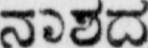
ನಾಶದ
